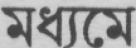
মধ্যমে
